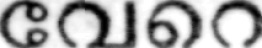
വേറെ
